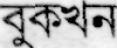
বুকখন
